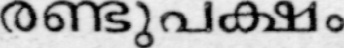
രണ്ടുപക്ഷം
